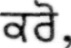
ਕਰੋ,
